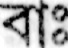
বাঃ
